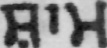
ਸ਼ਾਮ
